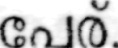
പേര്.
